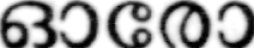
ഓരോ
